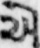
એ
